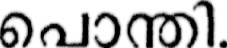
പൊന്തി.
